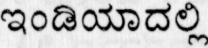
ಇಂಡಿಯಾದಲ್ಲಿ
